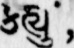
કહ્યું,
